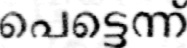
പെട്ടെന്ന്
